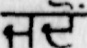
ਜਦੋਂ
